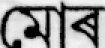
মোৰ
